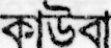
কাউপা
